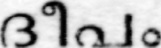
ദീപം
